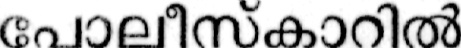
പോലീസ്കാറില്‍
